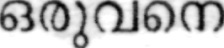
ഒരുവനെ
